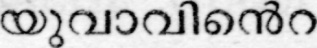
യുവാവിന്റെ
